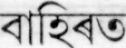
বাহিৰত
